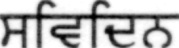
ਸਵਿਦਿਨ
